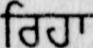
ਰਿਹਾ
